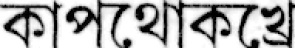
কাপথোকখ্রে
